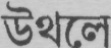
উথলে
